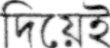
দিয়েই
